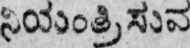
ನಿಯಂತ್ರಿಸುವ
